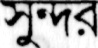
সুন্দর
